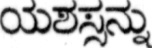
ಯಶಸ್ಸನ್ನು
